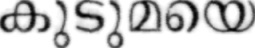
കുടുമയെ
